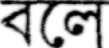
বলে
